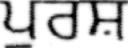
ਪੁਰਸ਼
